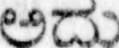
ಅದು
